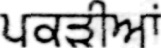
ਪਕੜੀਆਂ
